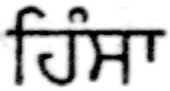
ਹਿੰਸਾ
